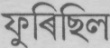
ফুৰিছিল
